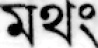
মথং
